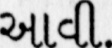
આવી.
